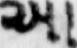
આ
